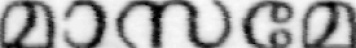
മാസമേ
